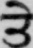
ਤੇ
